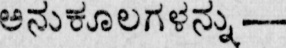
ಅನುಕೂಲಗಳನ್ನು-
